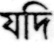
যদি
